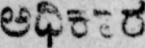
ಅಧಿಕಾರ
